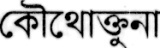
কৌথোক্তুনা
